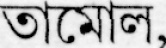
তামোল,
